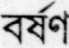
বর্ষণ
